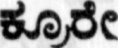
ಕ್ರೂರೇ
